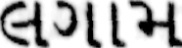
લગામ
